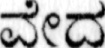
ವೇದ
